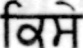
ਕਿਸੇ
